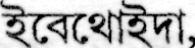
ইবেথোইদা,
